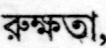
রুক্ষতা,
